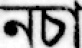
নচা
